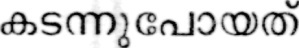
കടന്നുപോയത്
